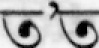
ত'ত
